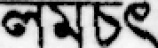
লমচৎ
